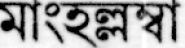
মাংহল্লম্বা
